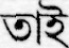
তাই
